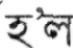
হ'ল
